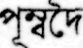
পূম্বদৈ
